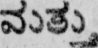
ಮತ್ತು
